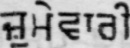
ਜ਼ੁਮੇਵਾਰੀ
